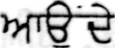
ਆਉਂਦੇ
